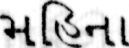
મહિના
